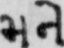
મને
